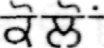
ਕੋਲੋਂ
